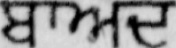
ਬਾਅਦ
